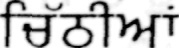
ਚਿੱਠੀਆਂ
